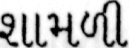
શામળી
